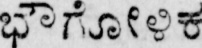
ಭೌಗೋಳಿಕ
